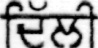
ਦਿੱਲੀ
